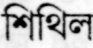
শিথিল
